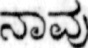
ನಾವು
